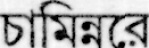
চামিন্নরে
